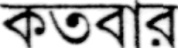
কতবার
